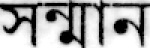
সন্মান
